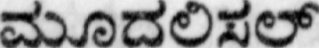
ಮೂದಲಿಸಲ್
